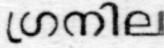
ഗ്രനില
